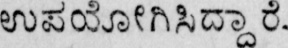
ಉಪಯೋಗಿಸಿದ್ದಾರೆ.
